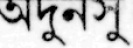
অদুনসু
